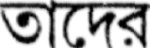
তাদের
